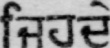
ਜਿਹਦੇ
